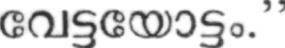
വേട്ടയോട്ടം."
